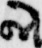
જો
